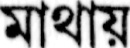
মাথায়
